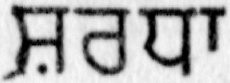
ਸ਼ਰਧਾ
